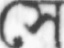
সে
